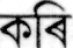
কৰি
